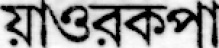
য়াওরকপা
